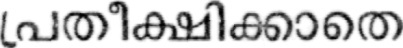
പ്രതീക്ഷിക്കാതെ
